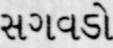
સગવડો
